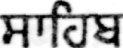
ਸਾਹਿਬ
